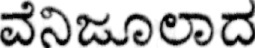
ವೆನಿಜೂಲಾದ
